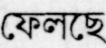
ফেলছে
